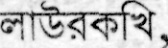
লাউরকখি,
